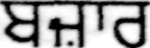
ਬਜ਼ਾਰ
